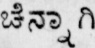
ಚೆನ್ನಾಗಿ
